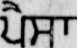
ਪੈਸਾ
